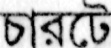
চারটে
